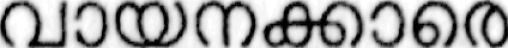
വായനക്കാരെ
